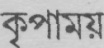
কৃপাময়
